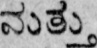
ಮತ್ತು
